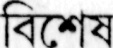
বিশেষ
